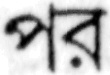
পর
